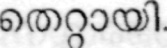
തെറ്റായി.
